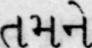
તમને
